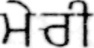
ਮੇਰੀ
